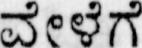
ವೇಳೆಗೆ
